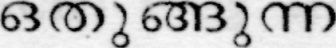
ഒതുങ്ങുന്ന
